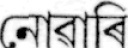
নোৱাৰি
